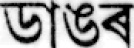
ডাঙৰ
